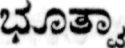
ಭೂತ್ವಾ
